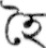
হৈ
